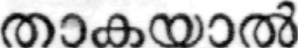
താകയാല്‍
